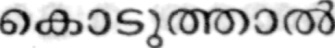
കൊടുത്താല്‍
